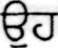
ਉਹ
